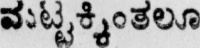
ಮಟ್ಟಕ್ಕಿಂತಲೂ
